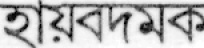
হায়বদমক
